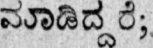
ಮಾಡಿದ್ದರೆ;
